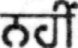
ਨਹੀਂ
